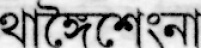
থাঙ্গৈশেংনা
